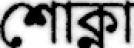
শোক্না
